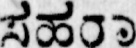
ಸಹರಾ
